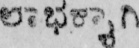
ಲಾಭಕ್ಕಾಗಿ
